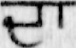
ਦਾ
